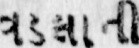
વડલાની
